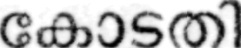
കോടതി
